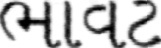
ભાવટ
